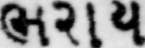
ભરાય
